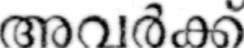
അവര്‍ക്ക്
